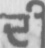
ਦੀ
